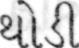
થોડી
